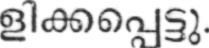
ളിക്കപ്പെട്ടു.
